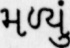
મળ્યું
